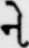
ને
